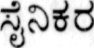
ಸೈನಿಕರ
